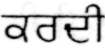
ਕਰਦੀ
